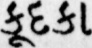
કૂદકા
